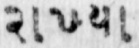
રાખ્યા
